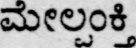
ಮೇಲ್ಪ೦ಕ್ತಿ
